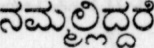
ನಮ್ಮಲ್ಲಿದ್ದರೆ
